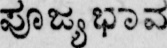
ಪೂಜ್ಯಭಾವ
